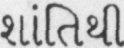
શાંતિથી
